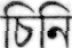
চিনি
